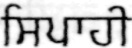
ਸਿਪਾਹੀ
